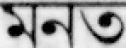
মনত
